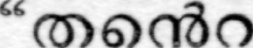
"തന്റെ
